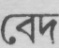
বেদ
